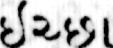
ઈચ્છા
